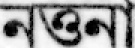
নত্তনা
